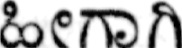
ಹೀಗಾಗಿ
